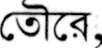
তৌরে,
